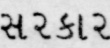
સરકાર
